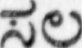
ಸಲ
